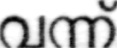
വന്ന്
